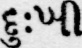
દુઃખી
